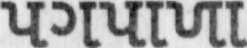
પગપાખા
